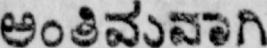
ಅಂತಿಮವಾಗಿ
